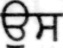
ਉਸ
